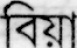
বিয়া
